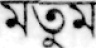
মতুম
